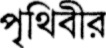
পৃথিবীর
